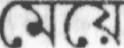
মেয়ে
